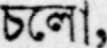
চলো,
